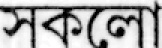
সকলো
